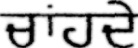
ਚਾਂਹਦੇ
